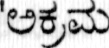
ಅಕ್ರಮ
